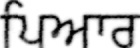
ਪਿਆਰ
